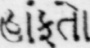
હાંફતો
